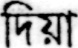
দিয়া
